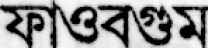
ফাওবগুম
